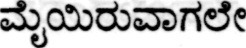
ಮೈಯಿರುವಾಗಲೇ
